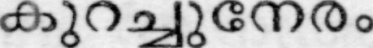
കുറച്ചുനേരം
